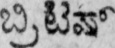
ಬ್ರಿಟಿಷ್
